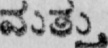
ಮತ್ತು
